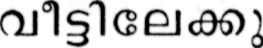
വീട്ടിലേക്കു
